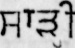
ਸਾੜ੍ਹੀ
